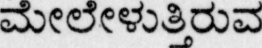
ಮೇಲೇಳುತ್ತಿರುವ
